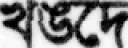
খঙদে
